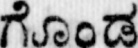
ಗೊಂಡ
